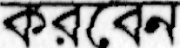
করবেন
